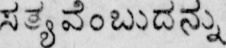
ಸತ್ಯವೆಂಬುದನ್ನು
